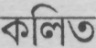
কলিত
